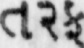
તરફ
